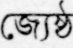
জ্যেষ্ঠ
